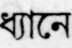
ধ্যানে
